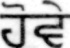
ਹੋਵੇ
